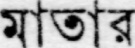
মাতার
